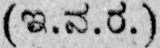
(ಇ.ವ.ರ.)
